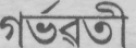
গৰ্ভৱতী
